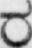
ರ
